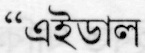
"এইডাল
